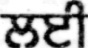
ਲਈ
